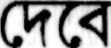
দেবে
